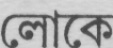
লোকে
